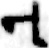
ન
